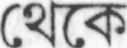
থেকে
